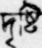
দৃষ্টি
